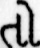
તો
